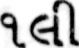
૧લી
